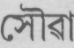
সৌৱা
